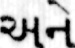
અને
